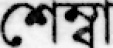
শেম্বা
